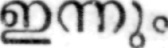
ഇന്നും
